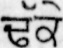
ਢੱਕੇ
